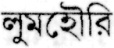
লুমহৌরি
